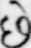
છે
